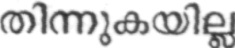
തിന്നുകയില്ല.
